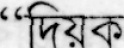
"দিয়ক
